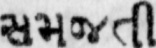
સમજતી
